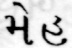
મેહ
